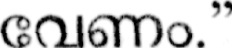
വേണം.”
